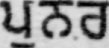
ਪੁਨਰ
